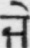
ਜੇ
